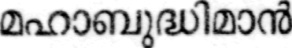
മഹാബുദ്ധിമാന്‍
